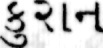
કુરાન
